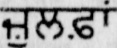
ਜ਼ੁਲਫ਼ਾਂ
